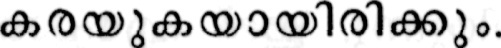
കരയുകയായിരിക്കും.
